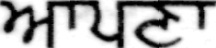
ਆਪਣਾ
